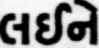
લઈને
